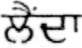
ਲੈਂਦਾ
